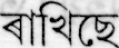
ৰাখিছে
